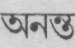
অনন্ত
